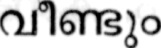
വീണ്ടും
